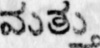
ಮತ್ತು
